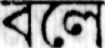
বলে
